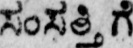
ಸಂಸತ್ತಿಗೆ
